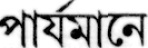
পার্যমানে
